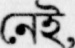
নেই,
